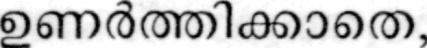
ഉണര്‍ത്തിക്കാതെ,
